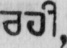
ਰਹੀ,
